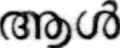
ആള്‍
